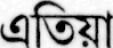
এতিয়া
